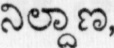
ನಿಲ್ದಾಣ,
